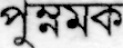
পুম্নমক
